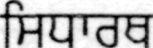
ਸਿਧਾਰਥ
